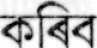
কৰিব
